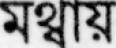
মথ্বায়
